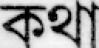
কথা
